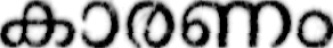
കാരണം
